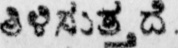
ತಿಳಿಸುತ್ತದೆ.
